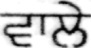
ਵਾਲੇ
